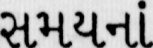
સમયનાં
